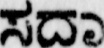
ಸದಾ
